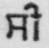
ਸੀ
